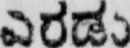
ಎರಡು
